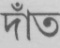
দাঁত
